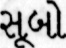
સૂબો
